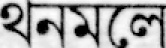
থনমলে
